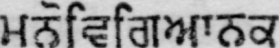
ਮਨੋਵਿਗਿਆਨਕ
